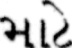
માટે
